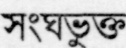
সংঘভুক্ত
